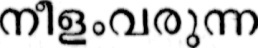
നീളംവരുന്ന
